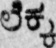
ಲೆಕ್ಕ
